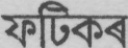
ফটিকৰ
